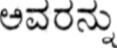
ಅವರನ್ನು
